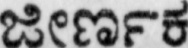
ಜೀರ್ಣಕ
